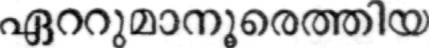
ഏററുമാനൂരെത്തിയ
